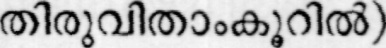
തിരുവിതാംകൂറില്‍)
